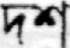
দশ
